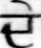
ਦੇ
